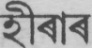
হীৰাৰ
